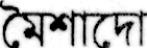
মৈশাদো
